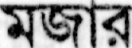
মজার
